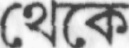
থেকে
